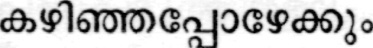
കഴിഞ്ഞപ്പോഴേക്കും
